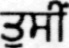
ਤੁਸੀਂ
